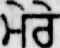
ਮੇਰੇ
